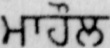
ਮਾਹੌਲ
